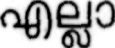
എല്ലാ
